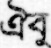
ঐবু
